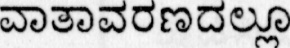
ವಾತಾವರಣದಲ್ಲೂ
